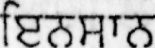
ਇਨਸਾਨ
